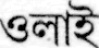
ওলাই
